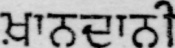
ਖ਼ਾਨਦਾਰੀ
